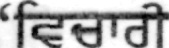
'ਵਿਚਾਰੀ
